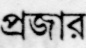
প্রজার
